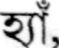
হ্যাঁ,
